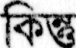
কিন্তু
